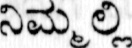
ನಿಮ್ಮಲ್ಲಿ
